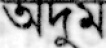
অদুম
